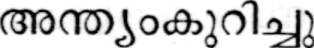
അന്ത്യംകുറിച്ചു
